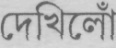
দেখিলোঁ
